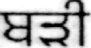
ਬੜੀ
